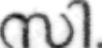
സി.
